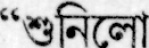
"শুনিলো
